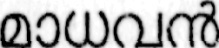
മാധവന്‍
